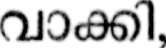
വാക്കി,
